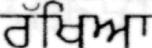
ਰੱਖਿਆ
